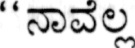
"ನಾವೆಲ್ಲ
